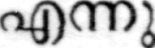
എന്നു
